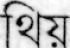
থিয়
